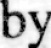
by
